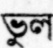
ভুল
